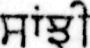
ਸਾਂਝੀ
